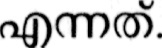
എന്നത്.
